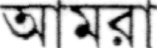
আমরা
